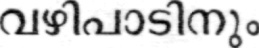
വഴിപാടിനും
